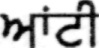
ਆਂਟੀ
